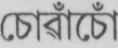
চোৱাঁচোঁ
